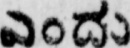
ಎಂದು
